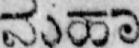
ಮಹಾ
